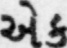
એક
